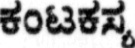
ಕಂಟಕಸ್ಯ
